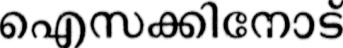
ഐസക്കിനോട്
